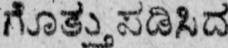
ಗೊತ್ತುಪಡಿಸಿದ
